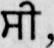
ਸੀ,
